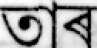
তাৰ
